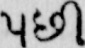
પછી
